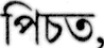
পিচত,
